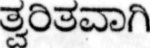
ತ್ವರಿತವಾಗಿ
